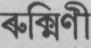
ৰুক্মিণী
